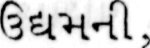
ઉધમની,
